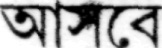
আসবে
